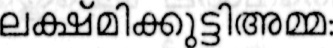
ലക്ഷ്മിക്കുട്ടിഅമ്മ:
